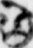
છે
